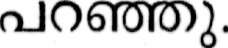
പറഞ്ഞു.
